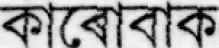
কাৰোবাক
